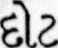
દોટ
